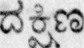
ದಕ್ಷಿಣ
